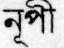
নূপী
